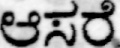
ಆಸರೆ
